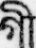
গী
